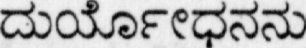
ದುರ್ಯೋಧನನು
